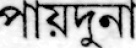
পায়দুনা
